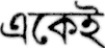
একেই
